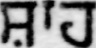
ਸ਼ਾਹ
